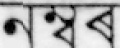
নম্বৰ
